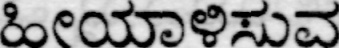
ಹೀಯಾಳಿಸುವ
